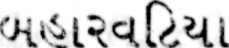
બહારવટિયા
